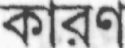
কারণ
